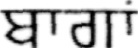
ਬਾਗਾਂ
